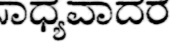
ಸಾಧ್ಯವಾದರೆ
